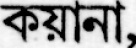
কয়ানা,
